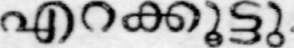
എറക്കൂട്ടു.
